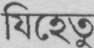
যিহেতু
